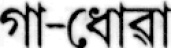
গা-ধোৱা
